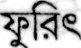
ফুরিৎ
